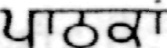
ਪਾਠਕਾਂ
